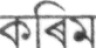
কৰিম
